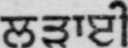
ਲੜਾਈ
